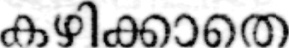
കഴിക്കാതെ
